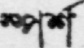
স্পর্শ
